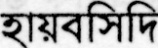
হায়বসিদি
